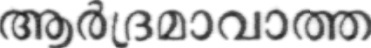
ആര്‍ദ്രമാവാത്ത
